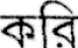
করি
